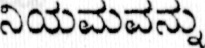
ನಿಯಮವನ್ನು
